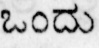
ಒಂದು
